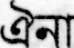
ঐনা
